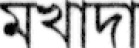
মখাদা
